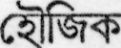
হৌজিক
